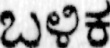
ಬಳಿಕ
